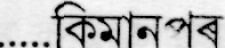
.....কিমানপৰ
